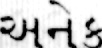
અનેક
